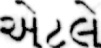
એટલે
